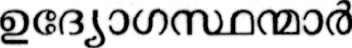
ഉദ്യോഗസ്ഥന്മാര്‍
